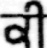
ਕੀ
